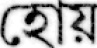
হোয়
